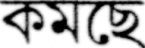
কমছে
